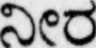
ನೀರ
